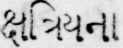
ક્ષત્રિયનાં
